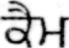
ਕੈਮ
